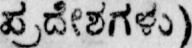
ಪ್ರದೇಸಗಳು)
